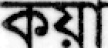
কয়া
